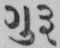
ગુરૂ
